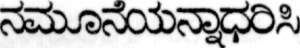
ನಮೂನೆಯನ್ನಾಧರಿಸಿ
